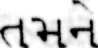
તમને
